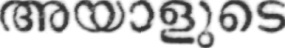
അയാളുടെ
